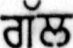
ਗੱਲ
